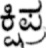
ಕ್ಷಿಪ್ರ
